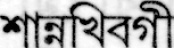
শান্নখিবগী
